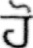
ਹੋ
